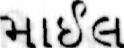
માઈલ
